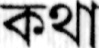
কথা
